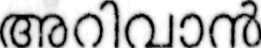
അറിവാന്‍
